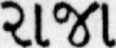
રાજા
